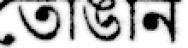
তোঙান
